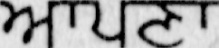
ਆਪਣਾ
